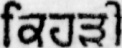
ਕਿਹੜੀ
